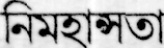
নিমহান্সতা
